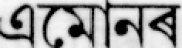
এমোনৰ
